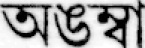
অঙম্বা
